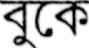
বুকে
